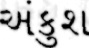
અંકુશ
